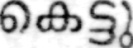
കെട്ടു
